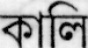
কালি
